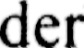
der
